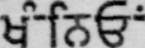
ਖੰਨਿਓਂ
